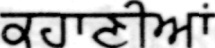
ਕਹਾਣੀਆਂ
